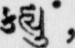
કહ્યું,
